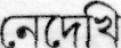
নেদেখি
